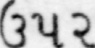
ઉપર
